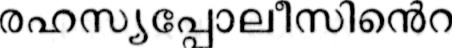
രഹസ്യപ്പോലീസിന്റെ
